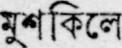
মুশকিলে
